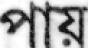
পায়
